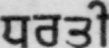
ਧਰਤੀ
